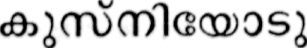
കുസ്നിയോടു
